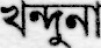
খন্দুনা
